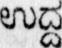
ಉದ್ದ
